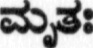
ಮೃತಃ
